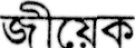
জীয়েক
